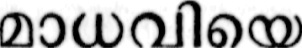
മാധവിയെ
